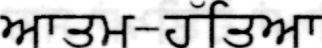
ਆਤਮ-ਹੱਤਿਆ
